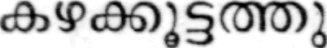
കഴക്കൂട്ടത്തു
